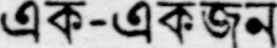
এক-একজন
